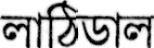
লাঠিডাল
